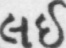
લઈ
